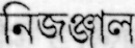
নিজঞ্জাল
